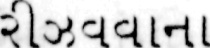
રીઝવવાના
